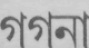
গগনা
